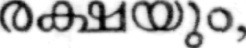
രക്ഷയും,
